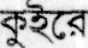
কুইরে
